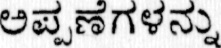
ಅಪ್ಪಣೆಗಳನ್ನು
